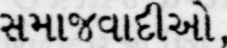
સમાજવાદીઓ,
